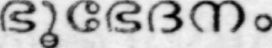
ഭൂഭേദനം
